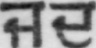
ਜਦ
